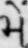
મેં
